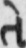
તે
